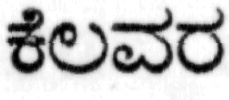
ಕೆಲವರ
